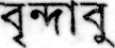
বৃন্দাবু
